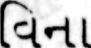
વિના
